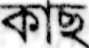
কাছ
